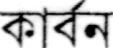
কার্বন
